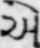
એ
